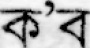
ক'ব
